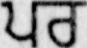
ਪਰ
